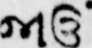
જાઉં
